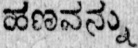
ಹಣವನ್ನು
